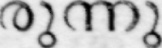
രുന്നു
